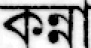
কন্না
